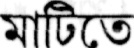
মাটিতে
